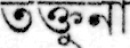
তক্তুনা
